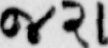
જરા
